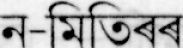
ন-মিতিৰৰ
